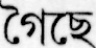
গৈছে
